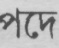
পদে
